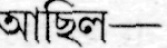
আছিল-
